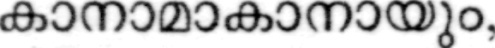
കാനാമാകാനായും,
